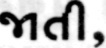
જાતી,
